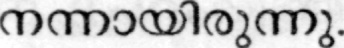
നന്നായിരുന്നു.
